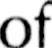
of
